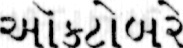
ઑક્ટોબરે
